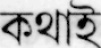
কথাই
